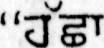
''ਹੱਛਾ
